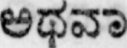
ಅಥವಾ
